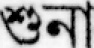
শুনা
